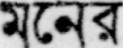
মনের
